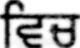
ਵਿਚ
